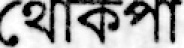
থোকপা
